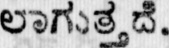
ಲಾಗುತ್ತದೆ.
